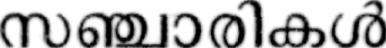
സഞ്ചാരികള്‍
